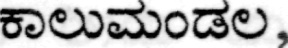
ಕಾಲುಮಂಡಲ,
